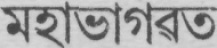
মহাভাগৱত
